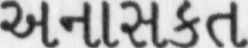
અનાસકત
